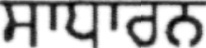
ਸਾਧਾਰਨ
